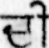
ਦੀ
